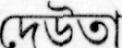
দেউতা
